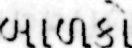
બાળકો
